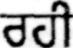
ਰਹੀ
